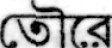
তৌরে
